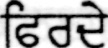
ਫਿਰਦੇ
